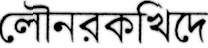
লৌনরকখিদে
